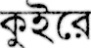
কুইরে
